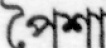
পৈশা
